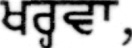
ਖਰ੍ਹਵਾ,
